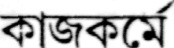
কাজকর্মে
